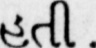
હતી.
